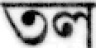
তল
